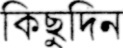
কিছুদিন
